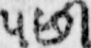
પછી
